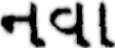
નવા
